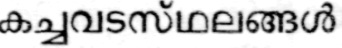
കച്ചവടസ്ഥലങ്ങള്‍
